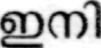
ഇനി
